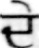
ਦੇ
